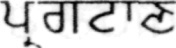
ਪ੍ਰਗਟਾਣ
